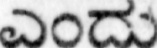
ಎಂದು
